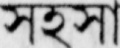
সহসা
